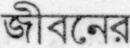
জীবনের
